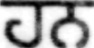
ਹਨ
